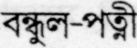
বন্ধুল-পত্নী
